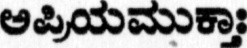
ಅಪ್ರಿಯಮುಕ್ತಾಃ
